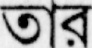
তার
